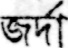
জর্দা
